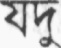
যদু
